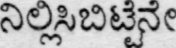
ನಿಲ್ಲಿಸಿಬಿಟ್ಟೆನೇ
